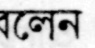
বলেন
